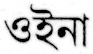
ওইনা
